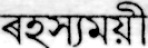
ৰহস্যময়ী
